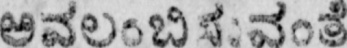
ಅವಲಂಬಿಸುವಂತೆ
